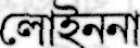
লোইননা
